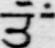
ਤੋਂ
